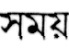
সময়
